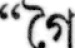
"গৈ
